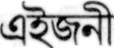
এইজনী
